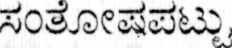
ಸಂತೋಷಪಟ್ಟು
